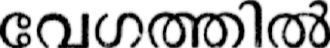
വേഗത്തില്‍
